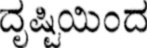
ದೃಷ್ಟಿಯಿಂದ
